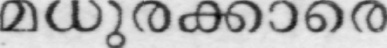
മധുരക്കാരെ
